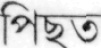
পিছত
